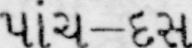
પાંચ-દસ
